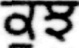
ਕੁਝ
